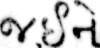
જઈને
